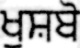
ਖੁਸ਼ਬੋ
